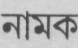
নামক
